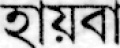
হায়বা
